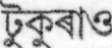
টুকুৰাও
